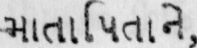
માતાપિતાને,
